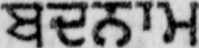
ਬਦਨਾਮ
